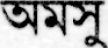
অমসু
